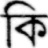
কি
